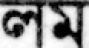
লম
